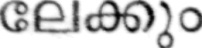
ലേക്കും
